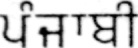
ਪੰਜਾਬੀ
